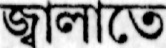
জ্বালাতে
